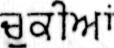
ਚੁਕੀਆਂ
